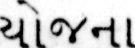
યોજના
